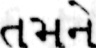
તમને
